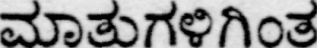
ಮಾತುಗಳಿಗಿ೦ತ
